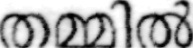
തമ്മില്‍
